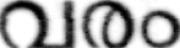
വരം
